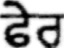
ਫੇਰ
